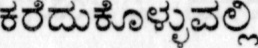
ಕರೆದುಕೊಳ್ಳುವಲ್ಲಿ
